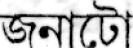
জনাটো
